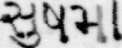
સુષમા
